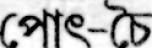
পোৎ-চৈ
